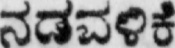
ನಡವಳಿಕೆ
